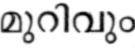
മുറിവും
